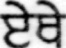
ਏਥੇ
